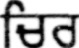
ਚਿਰ
